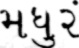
મધુરં
